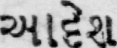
આદેશ
